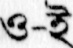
ও-ই
